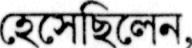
হেসেছিলেন,
